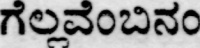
ಗೆಲ್ಲವೆಂಬಿನಂ
